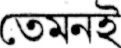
তেমনই
